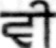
ਵੀ
